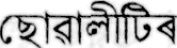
ছোৱালীটিৰ
